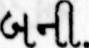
બની.
